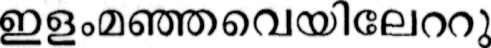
ഇളംമഞ്ഞവെയിലേററു
